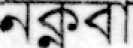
নক্নবা
